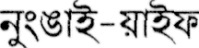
নুংঙাই-য়াইফ
